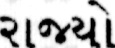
રાજ્યો
